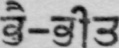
ਭੈ-ਭੀਤ
